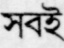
সবই
